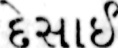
દેસાઈ
